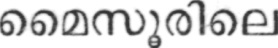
മൈസൂരിലെ
